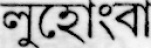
লুহোংবা
